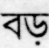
বড়
